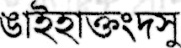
ঙাইহাক্তংদসু
